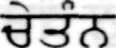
ਚੇਤੰਨ
